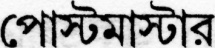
পোস্টমাস্টার
